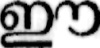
ഈ
